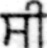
ਸੀ
